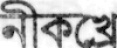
নীকখ্রে
